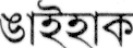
ঙাইহাক
